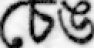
চেঙ
